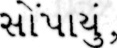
સોંપાયું,
